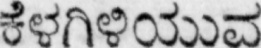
ಕೆಳಗಿಳಿಯುವ
